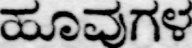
ಹೂವುಗಳ
